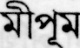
মীপুম
